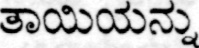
ತಾಯಿಯನ್ನು
